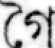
গৈ
